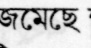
জমেছে
